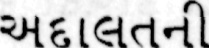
અદાલતની
